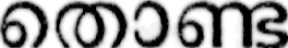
തൊണ്ട
